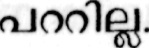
പററില്ല.
